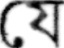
যে
